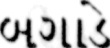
બગાડે
